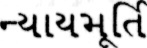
ન્યાયમૂર્તિ
